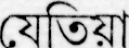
যেতিয়া
